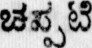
ಚಪ್ಪಟೆ
